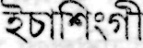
ইচাশিংগী
